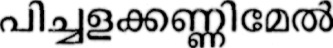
പിച്ചളക്കണ്ണിമേല്‍
